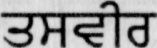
ਤਸਵੀਰ
